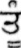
ਤੂੰ
